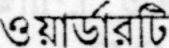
ওয়ার্ডারটি
